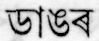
ডাঙৰ
